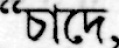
“চাদে,
